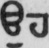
ਉਹ
